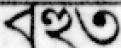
বহুত
